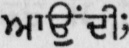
ਆਉਂਦੀ;
